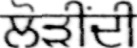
ਲੋੜੀਂਦੀ
